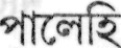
পালেহি
